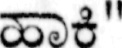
ಹಾಕಿ”
